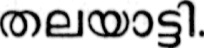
തലയാട്ടി.
